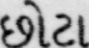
છોટા
